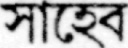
সাহেব
